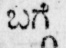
ಬಗ್ಗೆ
